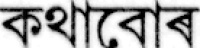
কথাবোৰ
